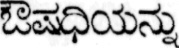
ಔಷಧಿಯನ್ನು
